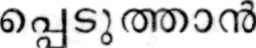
പ്പെടുത്താന്‍
